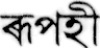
ৰূপহী
